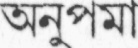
অনুপমা
